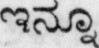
ಇನ್ನೂ
